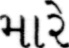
મારે
